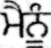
ਮੈਨੂੰ
